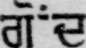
ਗੋਂਦ
